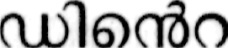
ഡിന്റെ
